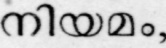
നിയമം,
